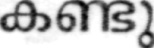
കണ്ടു
